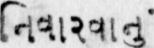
નિવારવાનું
